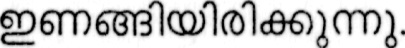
ഇണങ്ങിയിരിക്കുന്നു.
